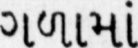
ગળામાં
